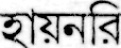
হায়নরি
